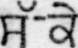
ਸੱਕੇ
